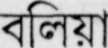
বলিয়া
